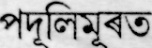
পদূলিমূৰত
